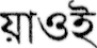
য়াওই
